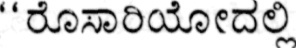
"ರೊಸಾರಿಯೋದಲ್ಲಿ
